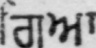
ਗਿਆ
